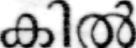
കില്‍
